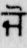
ਜੋ
